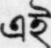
এই
